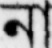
না
